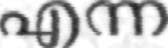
എന്ന
